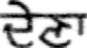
ਦੇਣਾ
